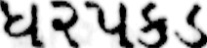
ધરપકડ
